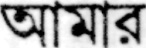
আমার
